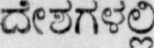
ದೇಶಗಳಲ್ಲಿ
